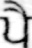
ਪੈ
